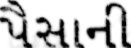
પૈસાની
